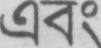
এবং
